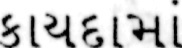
કાયદામાં
